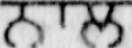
ਨਾਲ
